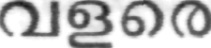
വളരെ
